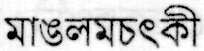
মাঙলমচৎকী
